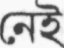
নেই
